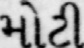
મોટી
